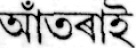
আঁতৰাই
